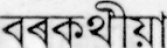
বৰকথীয়া
